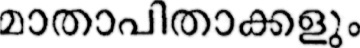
മാതാപിതാക്കളും
